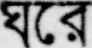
ঘরে
